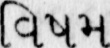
વિષમ
